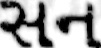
સન
